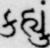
કહ્યું
